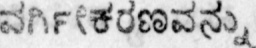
ವರ್ಗೀಕರಣವನ್ನು
